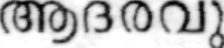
ആദരവു
